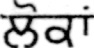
ਲੋਕਾਂ
